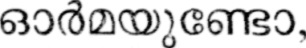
ഓര്‍മയുണ്ടോ,
